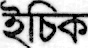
ইচিক
